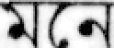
মনে
